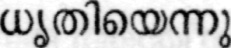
ധൃതിയെന്നു
